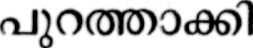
പുറത്താക്കി
